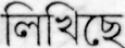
লিখিছে
